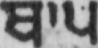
ਥਾਪ
